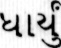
ધાર્યું
